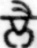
ਲੈ
